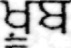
ਖ਼ੂਬ
